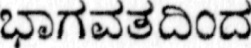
ಭಾಗವತದಿಂದ
